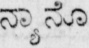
ನ್ಯಾನೊ
